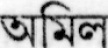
অমিল
